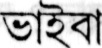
ভাইবা
